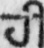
ਹੀ
